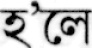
হ'লে
